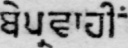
ਬੇਪ੍ਰਵਾਹੀਂ
